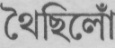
থৈছিলোঁ
